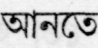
আনতে
